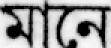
মানে
